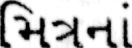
મિત્રનાં
